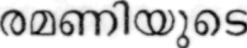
രമണിയുടെ
